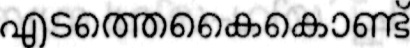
എടത്തെകൈകൊണ്ട്
